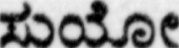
ಸುಯೋ
